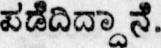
ಪಡೆದಿದ್ದಾನೆ.
